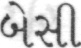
બેસી
